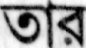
তার
